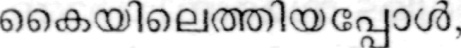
കൈയിലെത്തിയപ്പോള്‍,
